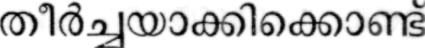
തീര്‍ച്ചയാക്കിക്കൊണ്ട്
